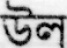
উল
